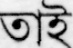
তাই
